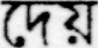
দেয়
